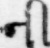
ની
